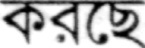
করছে
